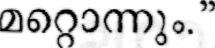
മറ്റൊന്നും."
